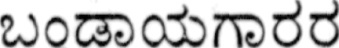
ಬಂಡಾಯಗಾರರ
